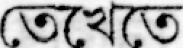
তেখেতে
